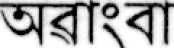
অৱাংবা
